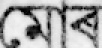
মোৰ
